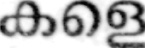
കളെ
